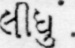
લીધું.
